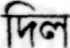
দিল
